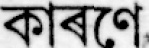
কাৰণে
